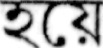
হয়ে
